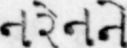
નરેનને
